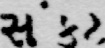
સંકટ
